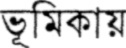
ভূমিকায়
